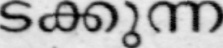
ടക്കുന്ന
